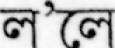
ল'লে
